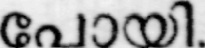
പോയി.
